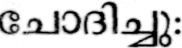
ചോദിച്ചു:
